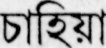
চাহিয়া
